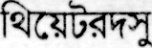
থিয়েটরদসু
